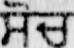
ਸੋਚ
